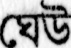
ঘেউ
